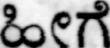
ಹೀಗೆ
